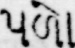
પળો
